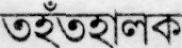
তহঁতহালক
